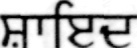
ਸ਼ਾਇਦ
